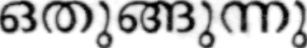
ഒതുങ്ങുന്നു
